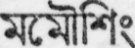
মমৌশিং
